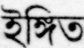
ইঙ্গিত
